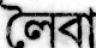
লৈবা
